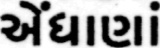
એંધાણાં
